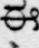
ಈ
